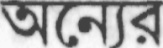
অন্যের
